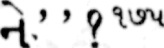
ને"?૧૭૫
